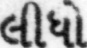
લીધો
